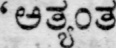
‘ಅತ್ಯಂತ
